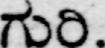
ಗುರಿ.
